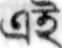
এই
